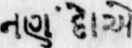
નણંદોએ
